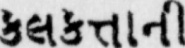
કલકત્તાની
